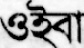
ওইবা
